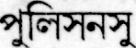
পুলিসনসু
